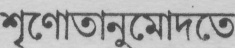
শৃণোতানুমোদতে
